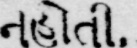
નહોતી.
